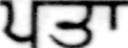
ਪਤਾ
